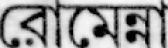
রোমেন্না
